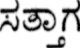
ಸತ್ತಾಗ
